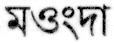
মওংদা
